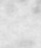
મેં
